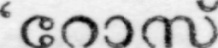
‘റോസ്
